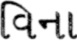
વિના
